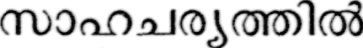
സാഹചര്യത്തില്‍
